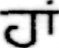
ਹਾਂ
